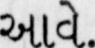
આવે.
